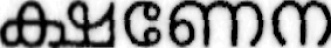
ക്ഷണേന
